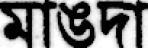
মাঙদা
